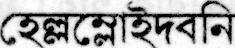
হেল্লম্লোইদবনি
